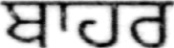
ਬਾਹਰ
